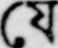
যে
